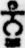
ਨੂੰ
